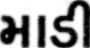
માડી
